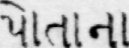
પોતાના
